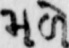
મળે?
